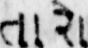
તારો
